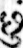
છું
